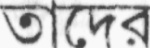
তাদের
